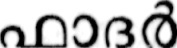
ഫാദര്‍
